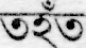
তহঁত
